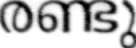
രണ്ടു
